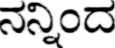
ನನ್ನಿಂದ
